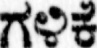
ಗಳಿಕೆ
